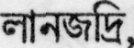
লানজদ্রি,
